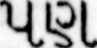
પણ
